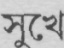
সুখে
